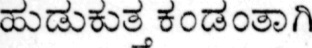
ಹುಡುಕುತ್ತಕಂಡಂತಾಗಿ
